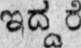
ಇದ್ದರೆ
